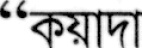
“কয়াদা
